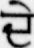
ਦੇ
